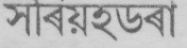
সৰিয়হডৰা
